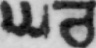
ਘਰ
